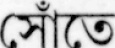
সোঁতে
